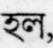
হল,
